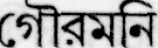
গৌরমনি
